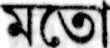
মতো
